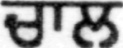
ਚਾਲ
